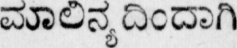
ಮಾಲಿನ್ಯದಿಂದಾಗಿ
